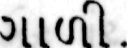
ગાળી.
